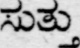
ಸುತ್ತು
